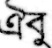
ঐবু
